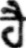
ਹੈ
